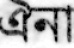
ঐনা
